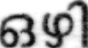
ഒഴി
